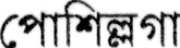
পোশিল্লগা
